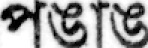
পঙাঙ
